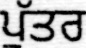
ਪੁੱਤਰ
